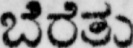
ಬೆರೆತು
